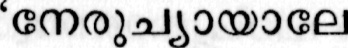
‘നേരുച്യായാലേ
